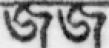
জজ
